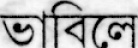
ভাবিলে
